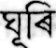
ঘূৰি
